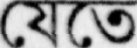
যেতে
